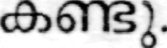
കണ്ടു.
